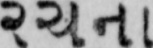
રચના
